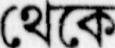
থেকে
